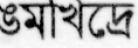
ঙমখিদ্রে
